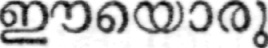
ഈയൊരു
